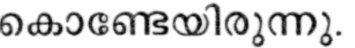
കൊണ്ടേയിരുന്നു.
